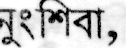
নুংশিবা,
